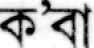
ক'বা
